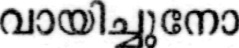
വായിച്ചുനോ
